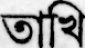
তাখি
